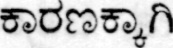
ಕಾರಣಕ್ಕಾಗಿ
